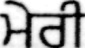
ਮੇਰੀ
